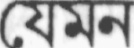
যেমন
